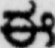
ಈ
